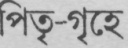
পিতৃ-গৃহে
